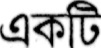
একটি
